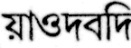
য়াওদবদি
